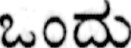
ಒಂದು
